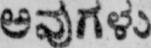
ಅವುಗಳು
